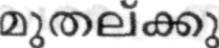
മുതല്ക്കു
